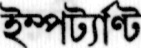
ইম্পর্ট্যাণ্ট
